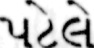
પટેલે
